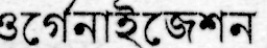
ওর্গেনাইজেশন
